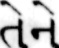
તેને
